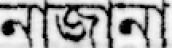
নাজানা
